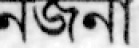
নজনা
